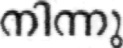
നിന്നു
